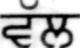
ਵੱਲ
